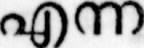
എന്ന
